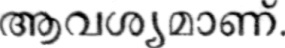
ആവശ്യമാണ്.
